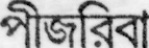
পীজরিবা
